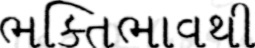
ભક્તિભાવથી
